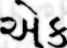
એક
